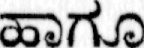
ಹಾಗೂ
